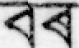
বৰ
